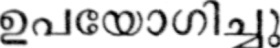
ഉപയോഗിച്ചു
